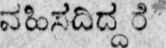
ವಹಿಸದಿದ್ದರೆ
